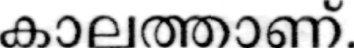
കാലത്താണ്.
